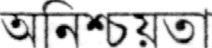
অনিশ্চয়তা
